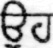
ਉਹ
